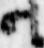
ન
